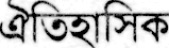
ঐতিহাসিক
